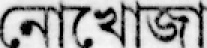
নোখোজা
